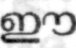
ഈ
